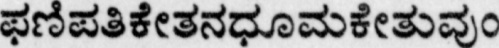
ಫಣಿಪತಿಕೇತನಧೂಮಕೇತುವುಂ
